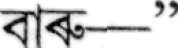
বাৰু-"
